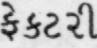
ફેકટરી
